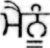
ਮੈਨੂੰ
